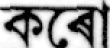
কৰো
